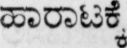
ಹಾರಾಟಕ್ಕೆ
